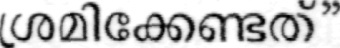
ശ്രമിക്കേണ്ടത്”
